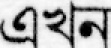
এখন
